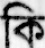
কি
